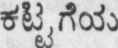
ಕಟ್ಟಿಗೆಯ
